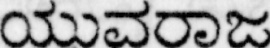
ಯುವರಾಜ
